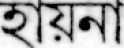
হায়না
